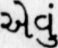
એવું
